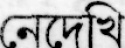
নেদেখি
